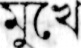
মুখে
